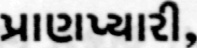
પ્રાણપ્યારી,
